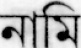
নামি
